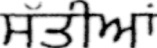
ਸੱਤੀਆਂ
